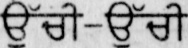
ਉੱਚੀ-ਉੱਚੀ
